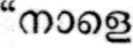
“നാളെ
